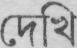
দেখি
